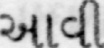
આવી
